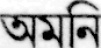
অমনি
